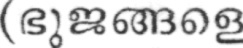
(ഭുജങ്ങളെ
